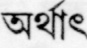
অর্থাত্
